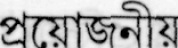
প্রয়োজনীয়
